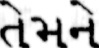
તેમને
